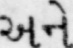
અને
